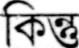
কিন্তু
